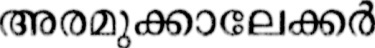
അരമുക്കാലേക്കര്‍
